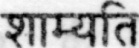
शाम्यति
